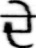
ਦੇ
